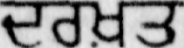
ਦਰਖ਼ਤ
